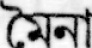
মৈনা
